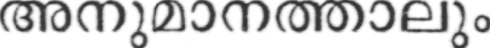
അനുമാനത്താലും
